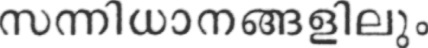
സന്നിധാനങ്ങളിലും
